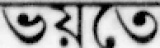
ভয়তে
